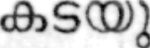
കടയു
